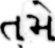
તમે
